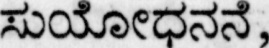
ಸುಯೋಧನನೆ,
